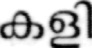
കളി
